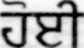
ਹੋਈ
